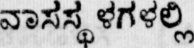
ವಾಸಸ್ಥಳಗಳಲ್ಲಿ
